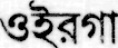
ওইরগা
